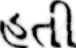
હતી
